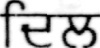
ਦਿਲ
